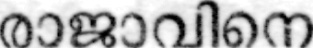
രാജാവിനെ
